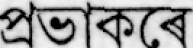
প্রভাকৰে
